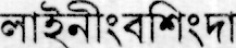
লাইনীংবশিংদা
